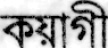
কয়াগী
